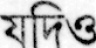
যদিও
